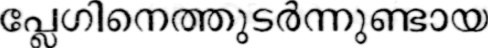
പ്ലേഗിനെത്തുടര്‍ന്നുണ്ടായ
